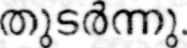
തുടര്‍ന്നു.
